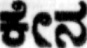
ಕೇನ
